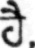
ਹੈ,
